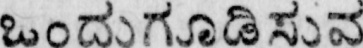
ಒಂದುಗೂಡಿಸುವ
